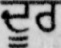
ਦੂਰ
